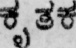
ಕೃತಕ
